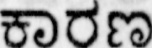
ಕಾರಣ
